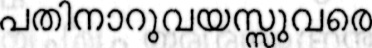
പതിനാറുവയസ്സുവരെ
